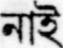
নাই
